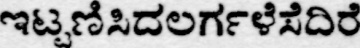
ಇಟ್ಟಣಿಸಿದಲರ್ಗಳೆಸೆದಿರೆ
